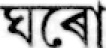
ঘৰো
